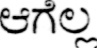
ಆಗೆಲ್ಲ
